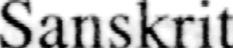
Sanskrit
